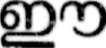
ഈ
